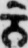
ਨੇ
